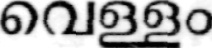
വെള്ളം
